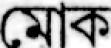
মোক
